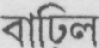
বাঢ়িল
